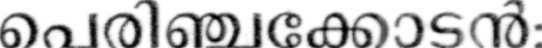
പെരിഞ്ചക്കോടന്‍:
